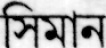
সিমান
